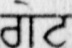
ਗੇਟ
